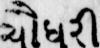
ચૌધરી
